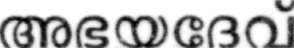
അഭയദേവ്
